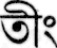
তীং
